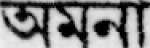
অমনা
